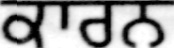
ਕਾਰਨ
